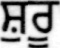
ਸ਼ੁਰੂ
